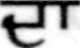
ਦਾ
